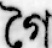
গৈ
